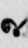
જ
